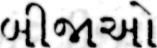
બીજાઓ
